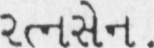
રત્નસેન.
